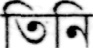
তিনি
